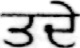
ਤਦੇ
